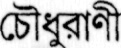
চৌধুরাণী
